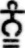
ਨੂੰ
